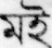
মই
